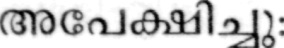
അപേക്ഷിച്ചു:
